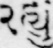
રહ્યું
